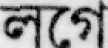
লগে
